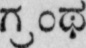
ಗ್ರಂಥ
